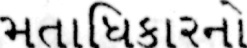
મતાધિકારનો
